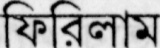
ফিরিলাম
